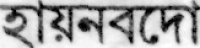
হায়নবদো
